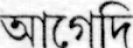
আগেদি
